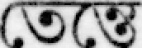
তেন্তে
